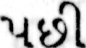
પછી
